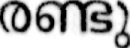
രണ്ടു
